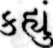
કહ્યું
